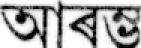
আৰম্ভ
